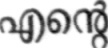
എന്റെ
